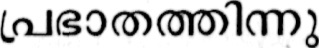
പ്രഭാതത്തിന്നു
